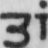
ਤਾਂ
